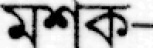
মশক-
